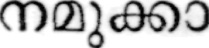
നമുക്കാ
